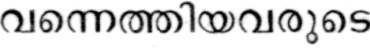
വന്നെത്തിയവരുടെ
